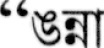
“ঙন্না
